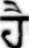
ਹੈ
